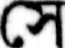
সে
